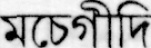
মচেগীদি
